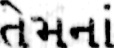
તેમનાં
